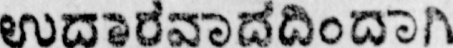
ಉದಾರವಾದದಿಂದಾಗಿ
